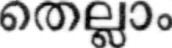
തെല്ലാം
